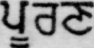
ਪੂਰਣ
